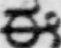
ಈ
